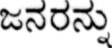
ಜನರನ್ನು
